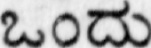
ಒಂದು
